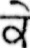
ਕੇ
